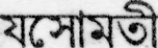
যসোমতী
